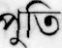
পুতি
